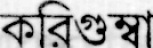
করিগুম্বা
